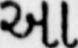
આ
